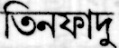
তিনফাদু
